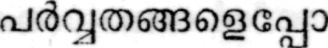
പര്‍വ്വതങ്ങളെപ്പോ
